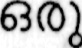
ഒരു
